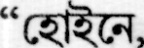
“হোইনে,
